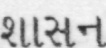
શાસન
